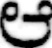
ಆ
